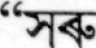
"সৰু
